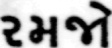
રમજો
